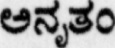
ಅನೃತಂ
